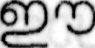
ഈ
